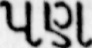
પણ
